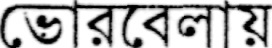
ভোরবেলায়
